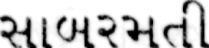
સાબરમતી
